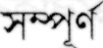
সম্পূর্ণ
